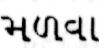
મળવા
